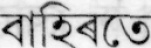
বাহিৰতে
